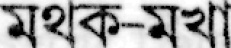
মথক-মখা
